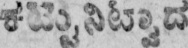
ಕಟ್ಟುನಿಟ್ಟಾದ
